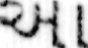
આ
